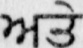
ਅਤੇ
